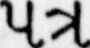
પત્ર
